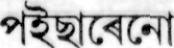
পইছাৰেনো
